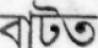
বাটত
